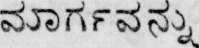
ಮಾರ್ಗವನ್ನು
